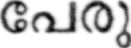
പേരു
